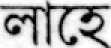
লাহে
